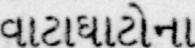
વાટાઘાટોના
